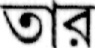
তার
